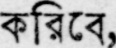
করিবে,
